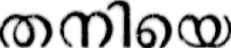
തനിയെ
